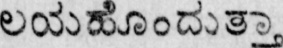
ಲಯಹೊಂದುತ್ತಾ
